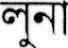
লুনা
